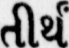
તીર્થ
